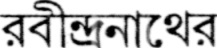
রবীন্দ্রনাথের
